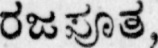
ರಜಪೂತ,
